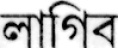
লাগিব
